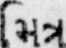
મિત્ર
